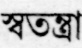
স্বতন্ত্রা
